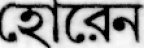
হোরেন
